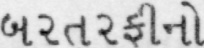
બરતરફીનો
